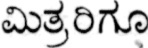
ಮಿತ್ರರಿಗೂ
